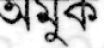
অমুক
